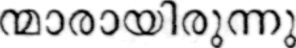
ന്മാരായിരുന്നു
